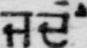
ਜਦੋਂ
